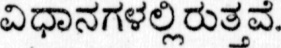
ವಿಧಾನಗಳಲ್ಲಿರುತ್ತವೆ.
